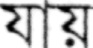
যায়
